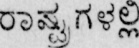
ರಾಷ್ಟ್ರಗಳಲ್ಲಿ
